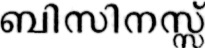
ബിസിനസ്സ്
